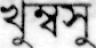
খুম্বসু
